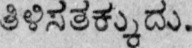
ತಿಳಿಸತಕ್ಕುದು.
